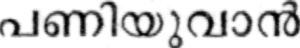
പണിയുവാന്‍
